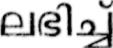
ലഭിച്ച്
